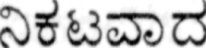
ನಿಕಟವಾದ
